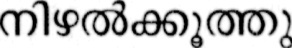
നിഴല്‍ക്കൂത്തു
